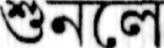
শুনলে
